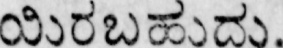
ಯಿರಬಹುದು.
